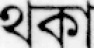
থকা
